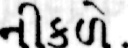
નીકળે.
